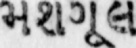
મશગૂલ
